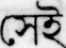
সেই
